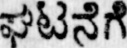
ಘಟನೆಗೆ
